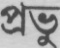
প্ৰভু
